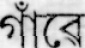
গাঁৱে
